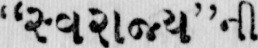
“સ્વરાજ્ય”ની
